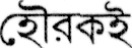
হৌরকই
